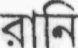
রানি
